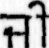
ਜੀ
